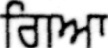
ਗਿਆ
